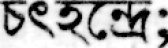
চৎহন্দ্রে;
